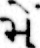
મેં
